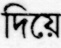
দিয়ে
